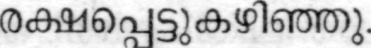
രക്ഷപ്പെട്ടുകഴിഞ്ഞു.
